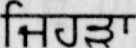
ਜਿਹੜਾ
